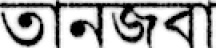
তানজবা
